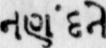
નણંદને
